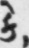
કે,
